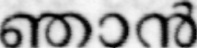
ഞാന്‍
